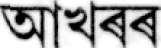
আখৰৰ
